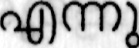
എന്നു
